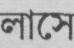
লাসে
